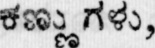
ಕಣ್ಣುಗಳು,
